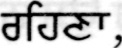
ਰਹਿਣਾ,
